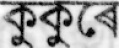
কুকুৰে
